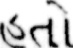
હતો
